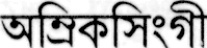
অম্রিকসিংগী
